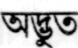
অদ্ভুত
